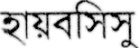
হায়বসিসু
